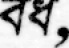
বধ,
